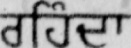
ਰਹਿੰਦਾ
